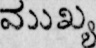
ಮುಖ್ಯ
